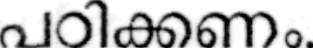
പഠിക്കണം.
